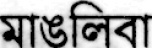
মাঙলিবা
